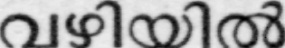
വഴിയില്‍
